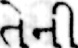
તેની
